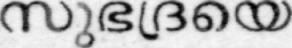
സുഭദ്രയെ
